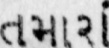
તમારાં
